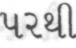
પરથી
